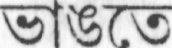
ভাঙতে
